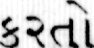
કરતો
